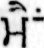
ਮੈਂ
